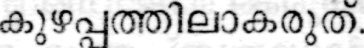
കുഴപ്പത്തിലാകരുത്.
